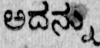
ಅದನ್ನು
